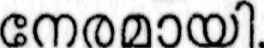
നേരമായി.
